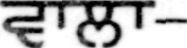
ਵਾਲਾ-
